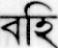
বহি
